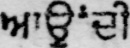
ਆਉਂਦੀ
